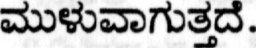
ಮುಳುವಾಗುತ್ತದೆ.
